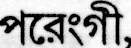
পরেংগী,
